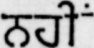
ਨਹੀਂ
